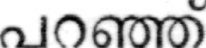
പറഞ്ഞ്
